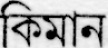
কিমান
